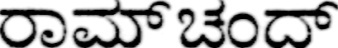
ರಾಮ್ಚಂದ್
